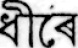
ধীৰে
